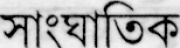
সাংঘাতিক
